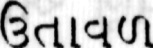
ઉતાવળ
